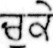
ਚੁਕੇ
